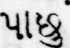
પાછું
